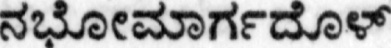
ನಭೋಮಾರ್ಗದೊಳ್
